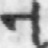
ન
